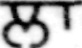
ਲਾ
